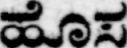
ಹೊಸ
